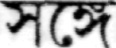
সঙ্গে
